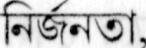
নির্জনতা,
